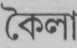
কৈলা
